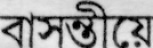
বাসন্তীয়ে
